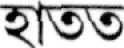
হাতত
